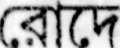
রোদে
